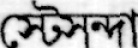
স্টেসন্দা
